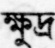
ক্ষুদ্র
